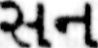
સન
